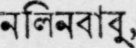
নলিনবাবু,
